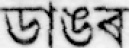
ডাঙৰ
